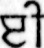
ਈ
